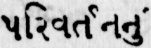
પરિવર્તનનું
